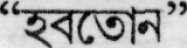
"হবতোন"
